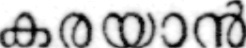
കരയാന്‍
